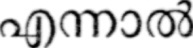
എന്നാല്‍
